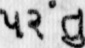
પરંતુ
